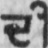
ਦੀ
